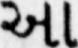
આ
